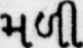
મળી
